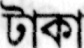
টাকা
